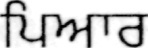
ਪਿਆਰ
